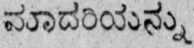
ಮಾದರಿಯನ್ನು
